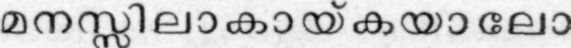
മനസ്സിലാകായ്കയാലോ
